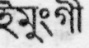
ইমুংগী
